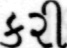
કરી
